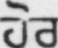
ਹੋਰ
